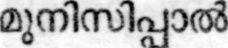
മുനിസിപ്പാല്‍
